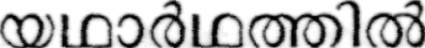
യഥാര്‍ഥത്തില്‍
